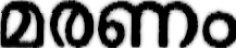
മരണം
